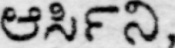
ಆರ್ಸಿನಿ,
